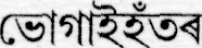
ভোগাইহঁতৰ
